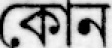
কোন
